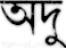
অদু
